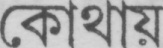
কোথায়
